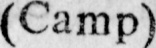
(Camp)
